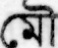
মৌ
